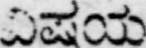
ವಿಷಯ
